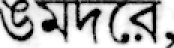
ঙমদরে,
